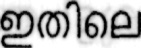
ഇതിലെ
